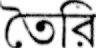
তৈরি
